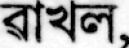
ৱাখল,
